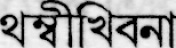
থম্বীখিবনা
